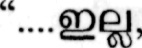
“....ഇല്ല.
